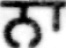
ਨਾ
